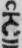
ਨੂੰ
